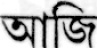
আজি
